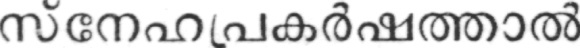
സ്നേഹപ്രകര്‍ഷത്താല്‍
